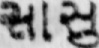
સાસુ
